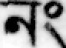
নং
